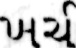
ખર્ચ
